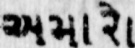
અમારો
